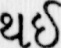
થઈ
